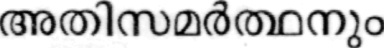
അതിസമര്‍ത്ഥനും
